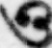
ও
